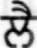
ਲੈ
